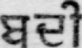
ਬਦੀ
